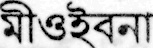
মীওইবনা
